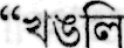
“খঙলি
